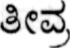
ತೀವ್ರ
